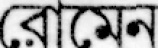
রোমেন
